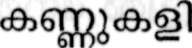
കണ്ണുകളി
